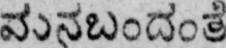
ಮನಬಂದಂತೆ
